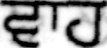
ਵਾਹ
